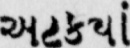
અટક્યાં
